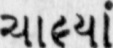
ચાલ્યાં
